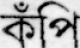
কঁপি
